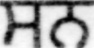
ਸਨ
